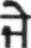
ਜੇ
